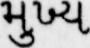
મુખ્ય
